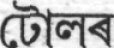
টোলৰ
